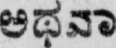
ಅಥವಾ
